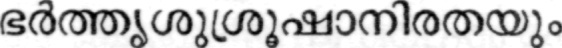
ഭര്‍ത്തൃശുശ്രൂഷാനിരതയും
